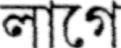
লাগে
